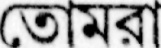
তোমরা
